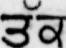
ਤੱਕ
